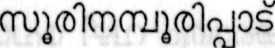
സൂരിനമ്പൂരിപ്പാട്
